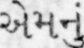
એમનું
